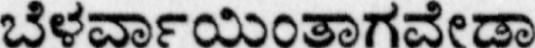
ಬೆಳರ್ವಾಯಿಂತಾಗವೇಡಾ
